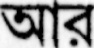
আর
